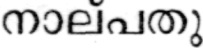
നാല്പതു
